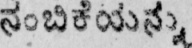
ನಂಬಿಕೆಯನ್ನು
